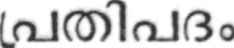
പ്രതിപദം
